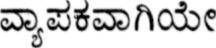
ವ್ಯಾಪಕವಾಗಿಯೇ
